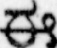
ಈ
